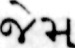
જેમ
